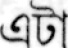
এটা
